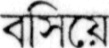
বসিয়ে
